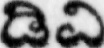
ಡಿವಿ
